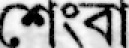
শেংবা
